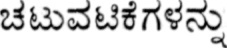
ಚಟುವಟಿಕೆಗಳನ್ನು
